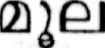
മൂല
